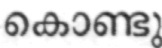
കൊണ്ടു
